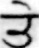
ਤੇ
